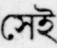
সেই
